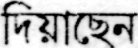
দিয়াছেন
